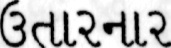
ઉતારનાર
